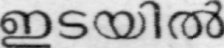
ഇടയില്‍
